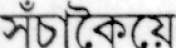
সঁচাকৈয়ে
